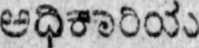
ಅಧಿಕಾರಿಯ
